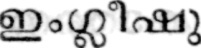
ഇംഗ്ലീഷു
